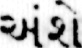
અંશે
